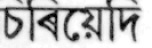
চিৰিয়েদি
